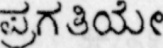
ಪ್ರಗತಿಯೇ
